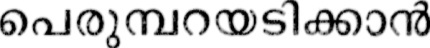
പെരുമ്പറയടിക്കാന്‍
